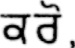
ਕਰੋ,
